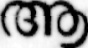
ആ
